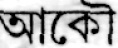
আকৌ
